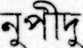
নুপীদু
